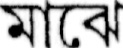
মাঝে
